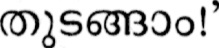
തുടങ്ങാം!'
